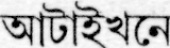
আটাইখনে
